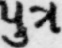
પુત્ર
